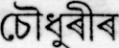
চৌধুৰীৰ
